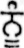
ਨੂੰ
